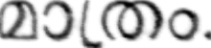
മാത്രം.
